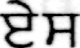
ਏਸ
